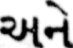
અને
